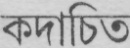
কদাচিত
